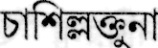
চাশিল্লক্তুনা
